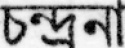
চন্দ্রনা
